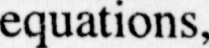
equations,
